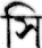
সি
